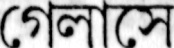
গেলাসে
